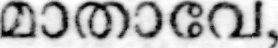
മാതാവേ,
